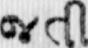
જતી
